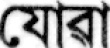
যোৱা
